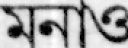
মনাও
